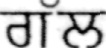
ਗੱਲ
